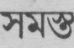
সমস্ত
